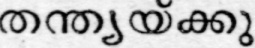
തന്ത്യയ്ക്കു
